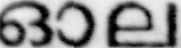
ഓല
